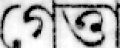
গেত্তা
